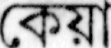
কেয়া
